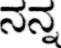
ನನ್ನ
